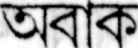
অবাক
